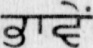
ਭਾਵੇਂ
